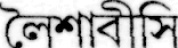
লৈশাবীসি
